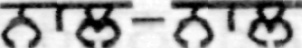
ਨਾਲ-ਨਾਲ
